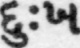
દુઃખ
